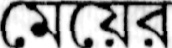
মেয়ের
